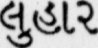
લુહાર
